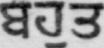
ਬਹੁਤ
